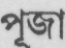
পূজা
